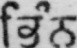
ਭਿੰਨ
